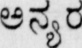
ಅನ್ಯರ
